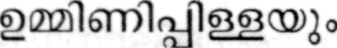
ഉമ്മിണിപ്പിള്ളയും
